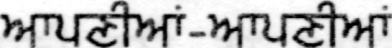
ਆਪਣੀਆਂ-ਆਪਣੀਆਂ
